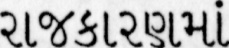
રાજકારણમાં
